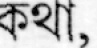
কথা,
